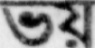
ভয়
